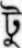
টু
